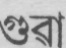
গুৱা
